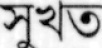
সুখত
